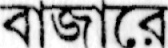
বাজারে
